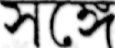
সঙ্গে
